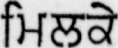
ਮਿਲਕੇ
